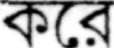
করে
